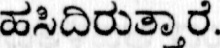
ಹಸಿದಿರುತ್ತಾರೆ.
